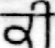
ਕੀ
